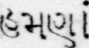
હમણાં
